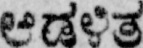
ಆಡಳಿತ
